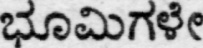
ಭೂಮಿಗಳೇ
